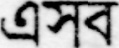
এসব
